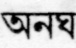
অনঘ
